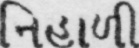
નિહાળી
